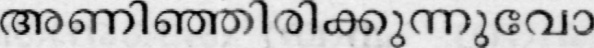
അണിഞ്ഞിരിക്കുന്നുവോ
